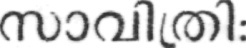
സാവിത്രി:
